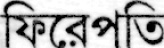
ফিরেপতি
